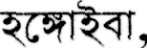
হঙ্গোইবা,
